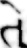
તે
